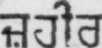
ਜ਼ਹੀਰ
